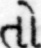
તો
